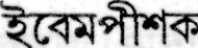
ইবেমপীশক
